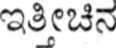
ಇತ್ತೀಚಿನ
